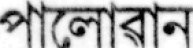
পালোৱান
